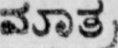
ಮಾತ್ರ
